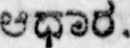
ಆಧಾರ.
